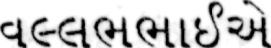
વલ્લભભાઈએ
